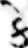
કે
